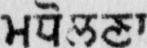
ਮਧੋਲਣਾ
